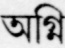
অগ্নি
